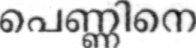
പെണ്ണിനെ
